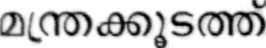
മന്ത്രക്കൂടത്ത്
